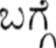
ಬಗ್ಗೆ
